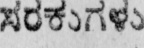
ಸರಕುಗಳು
